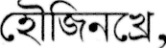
হৌজিনখ্রে,
